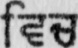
ਵਿਚ
